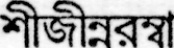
শীজীন্নরম্বা
